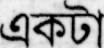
একটা
